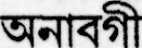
অনাবগী
